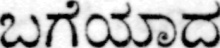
ಬಗೆಯಾದ
